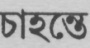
চাহন্তে
